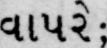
વાપરે;
